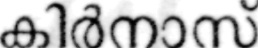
കിര്‍നാസ്
